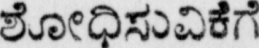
ಶೋಧಿಸುವಿಕೆಗೆ
